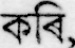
কৰি,
